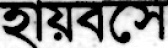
হায়বসে
